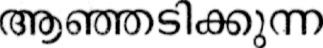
ആഞ്ഞടിക്കുന്ന
